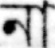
না
